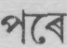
পৰে
